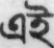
এই
